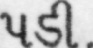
પડી.
